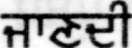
ਜਾਣਦੀ
